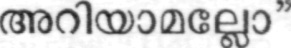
അറിയാമല്ലോ”
